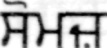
ਸੋਮਜ਼
